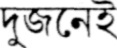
দুজনেই
